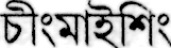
চীংমাইশিং
